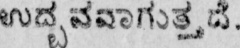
ಉದ್ಬವವಾಗುತ್ತದೆ.
